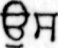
ਉਸ
